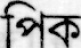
পিক
